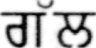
ਗੱਲ
